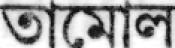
তামোল
